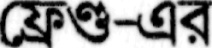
ফ্রেণ্ড-এর
